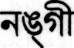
নঙগী
